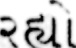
રહ્યો
